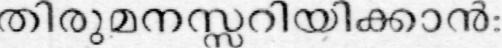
തിരുമനസ്സറിയിക്കാന്‍:
